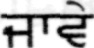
ਜਾਵੇ
